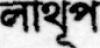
লাথূপ
